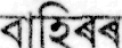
বাহিৰৰ
